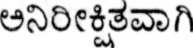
ಅನಿರೀಕ್ಷಿತವಾಗಿ
